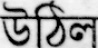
উঠিল
